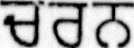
ਚਰਨ
